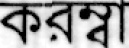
করম্বা
